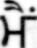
ਮੈਂ
